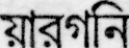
য়ারগনি
